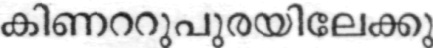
കിണററുപുരയിലേക്കു
